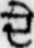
ਦੇ
